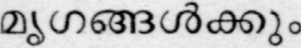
മൃഗങ്ങള്‍ക്കും
